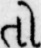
તો
